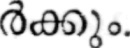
ര്‍ക്കും.
